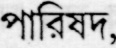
পারিষদ,
